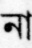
না
